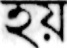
হয়
